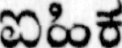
ಐಹಿಕ
